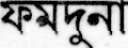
ফমদুনা
